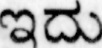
ಇದು
